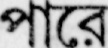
পারে
